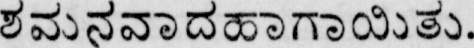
ಶಮನವಾದಹಾಗಾಯಿತು.
